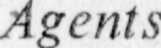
Agents
